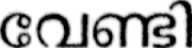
വേണ്ടി
